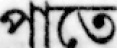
পাতে
